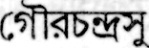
গৌরচন্দ্রসু
